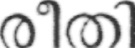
രീതി
